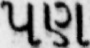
પણ
